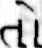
તો
